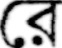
রে
